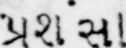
પ્રશંસા
